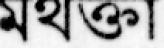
মথক্তা
